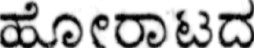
ಹೋರಾಟದ
